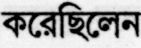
করেছিলেন
